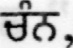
ਚੰਨ,
